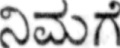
ನಿಮಗೆ
